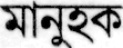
মানুহক
